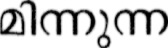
മിന്നുന്ന
